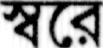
স্বরে
